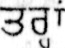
ਤਰ੍ਹਾਂ
